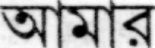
আমার
